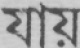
যায়
